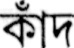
কাঁদ
